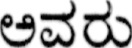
ಅವರು
